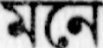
মনে
